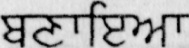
ਬਣਾਇਆ
